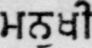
ਮਨੁਖੀ
